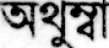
অথু্ম্বা
